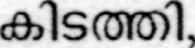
കിടത്തി,
